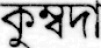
কুম্বদা
